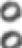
ঃ
